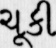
ચૂકી
